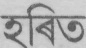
হৰিত
